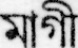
মাগী
